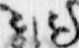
કોઈ
